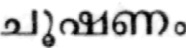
ചൂഷണം
